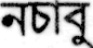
নচাবু
